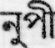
নুপী
